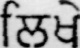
ਲਿਖੇ
